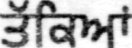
ਤੱਕਿਆਂ
